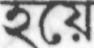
হয়ে
